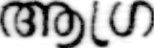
ആഗ്ര
